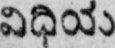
ವಿಧಿಯ
